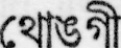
থাঙগী
